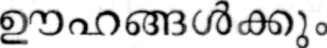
ഊഹങ്ങള്‍ക്കും
